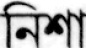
নিশা
